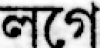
লগে
